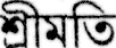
শ্রীমতি
